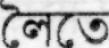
লৈতে
